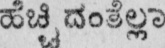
ಹೆಚ್ಚಿದಂತೆಲ್ಲಾ
